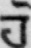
ਹੋ
